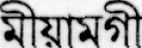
মীয়ামগী
